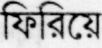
ফিরিয়ে
